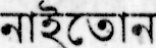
নাইতোন
